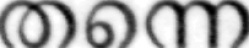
തന്നെ
